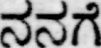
ನನಗೆ
